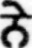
ਨੇ
